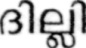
ദില്ലി
